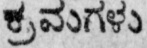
ಕ್ರಮಗಳು
